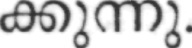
ക്കുന്നു.
